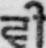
ਵੀ
